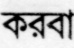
করবা
